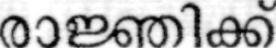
രാജ്ഞിക്ക്
